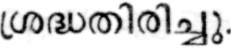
ശ്രദ്ധതിരിച്ചു.
